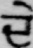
ਦੇ
